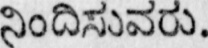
ನಿಂದಿಸುವರು.
